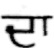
ਦਾ
